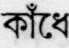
কাঁধে
